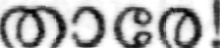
താരേ!
